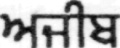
ਅਜੀਬ
